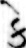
કે
